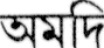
অমদি
